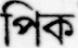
পিক
